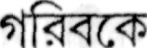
গরিবকে
